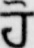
ਹੋ
